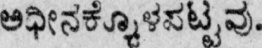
ಅಧೀನಕ್ಕೊಳಪಟ್ಟವು.
